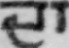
ਦਾ
